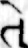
તે
